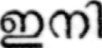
ഇനി
